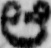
ಆ
